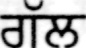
ਗੱਲ
